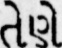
તેણે
